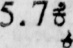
5.7ಕ್ಕೆ
